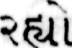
રહ્યો
